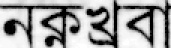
নক্নখ্রবা
